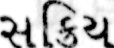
સક્રિય
